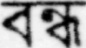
বন্ধ
